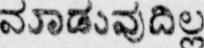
ಮಾಡುವುದಿಲ್ಲ
